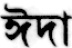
ঈদা
